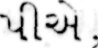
પીએ,
